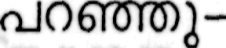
പറഞ്ഞു-
